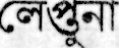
লেপ্তুনা
